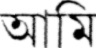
আমি
